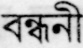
বন্ধনী
